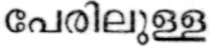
പേരിലുള്ള
